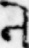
ને
